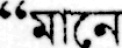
“মানে
